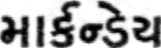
માર્કન્ડેય
